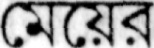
মেয়ের
